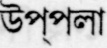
উপ্পলা
